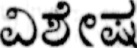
ವಿಶೇಷ
